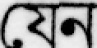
যেন
